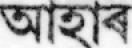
আহাৰ
